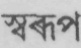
স্বৰূপ
